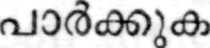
പാര്‍ക്കുക
